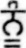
ਨੂੰ
